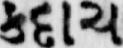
કદાચ
